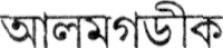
আলমগড়ীক
